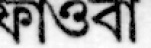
ফাওবা
